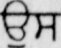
ਉਸ
